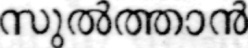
സുല്‍ത്താന്‍
